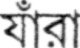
যাঁরা
